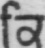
ਕਿ
